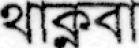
থাক্নবা
